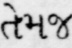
તેમજ
